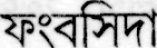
ফংবসিদা
